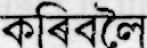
কৰিবলৈ
